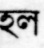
হল
